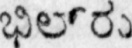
ಭಿಲ್‌ರು
